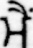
ਮੈਂ
